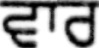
ਵਾਰ
